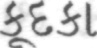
કૂદકા
